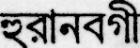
হুরানবগী
